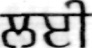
ਲਈ
